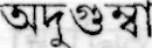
অদুগুম্বা
